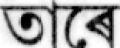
তাৰে
